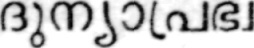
ദുന്യാപ്രഭ്വ
